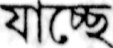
যাচ্ছে
